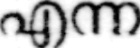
എന്ന
